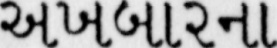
અખબારના
